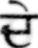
ਦੇ
